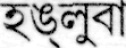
হঙলুবা
